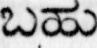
ಬಹು
